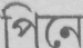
পিনে
